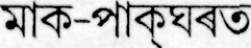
মাক-পাক্‌ঘৰত
